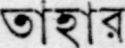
তাহার
